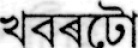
খবৰটো
